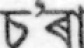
চ'ৰা
